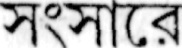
সংসারে
